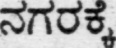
ನಗರಕ್ಕೆ
